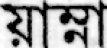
য়াম্না
